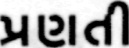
પ્રણતી
